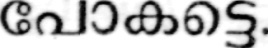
പോകട്ടെ.
